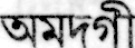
অমদগী
